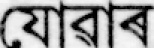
যোৱাৰ
